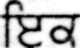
ਇਕ
